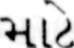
માટે
